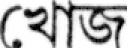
খোজ
